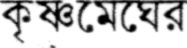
কৃষ্ণমেঘের
